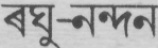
ৰঘু-নন্দন
